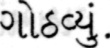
ગોઠવ્યું.
